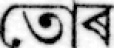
তোৰ
